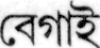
বেগাই
